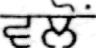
ਵਲੋਂ
